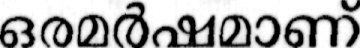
ഒരമര്‍ഷമാണ്
